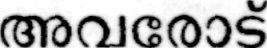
അവരോട്
